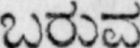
ಬರುವ
